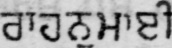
ਰਾਹਨੁਮਾਈ
